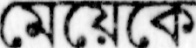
মেয়েকে
